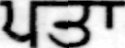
ਪਤਾ
